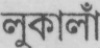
লুকালাঁ
